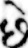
છે
